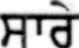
ਸਾਰੇ
